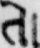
તો
